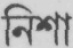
নিশা
